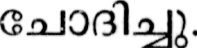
ചോദിച്ചു.
